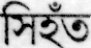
সিহঁত
